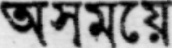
অসময়ে
